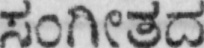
ಸಂಗೀತದ
